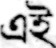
এই
